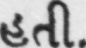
હતી.
